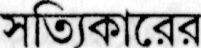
সত্যিকারের
